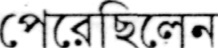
পেরেছিলেন
